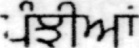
ਪੰਝੀਆਂ
